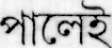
পালেই
